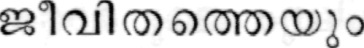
ജീവിതത്തെയും
